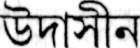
উদাসীন
